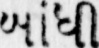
બાંધી
